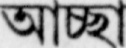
আচ্ছা
